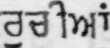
ਰੁਚੀਆਂ
